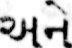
અને
